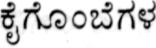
ಕೈಗೊಂಬೆಗಳ
